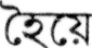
হৈয়ে
